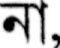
না,
